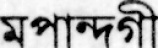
মপান্দগী
